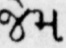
જેમ
